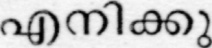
എനിക്കു
